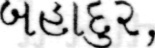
બહાદુર,
